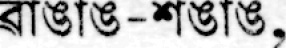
ৱাঙাঙ-শঙাঙ,
